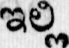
ಇಲ್ಲಿ
